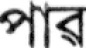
পাৱ
